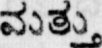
ಮತ್ತು
